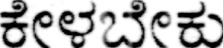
ಕೇಳಬೇಕು
